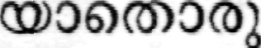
യാതൊരു
